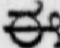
ಈ
